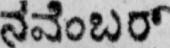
ನವೆಂಬರ್
